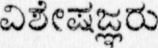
ವಿಶೇಷಜ್ಞರು
